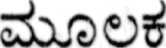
ಮೂಲಕ
